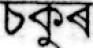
চকুৰ
